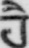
ਹੈ
